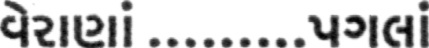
વેરાણાં.......પગલાં
